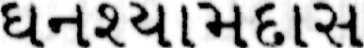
ઘનશ્યામદાસ
